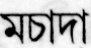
মচাদা
